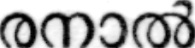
രനാല്‍
